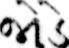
જોડે
